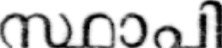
സ്ഥാപി
